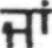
ਜਾਂ
